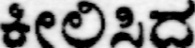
ಕೀಲಿಸಿದ
